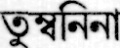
তুম্বনিনা
